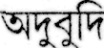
অদুবুদি
